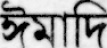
ঈমাদি
